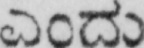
ಎಂದು
